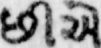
છીએ
